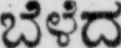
ಬೆಳೆದ
